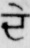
ਦੇ
